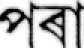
পৰা
